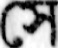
সে
